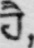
ਹੈ,
